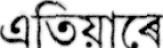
এতিয়াৰে
